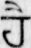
ਹੈ
